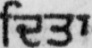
ਦਿਤਾ
